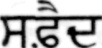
ਸਫ਼ੈਦ
